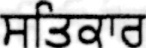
ਸਤਿਕਾਰ
